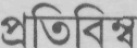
প্ৰতিবিম্ব
